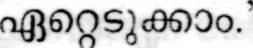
ഏറ്റെടുക്കാം.’
